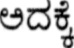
ಅದಕ್ಕೆ
